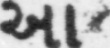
આ
